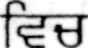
ਵਿਚ
